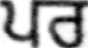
ਪਰ
